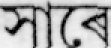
সাৰে
